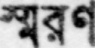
স্মরণ
